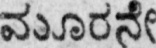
ಮೂರನೇ
